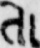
તો
